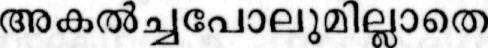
അകല്‍ച്ചപോലുമില്ലാതെ
